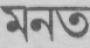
মনত
